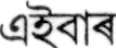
এইবাৰ
